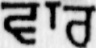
ਵਾਰ
